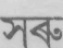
সৰু
